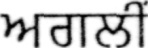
ਅਗਲੀ
